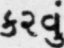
કરવું
